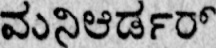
ಮನಿಆರ್ಡರ್
